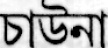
চাউনা
